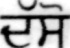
ਦੱਸੋ
